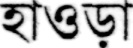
হাওড়া
